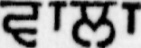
ਵਾਲਾ
